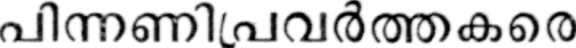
പിന്നണിപ്രവര്‍ത്തകരെ
